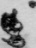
હું
